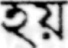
হয়
